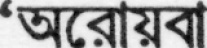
‘অরোয়বা
